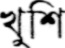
খুশি
